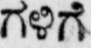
ಗಳಿಗೆ
